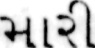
મારી
